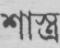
শাস্ত্ৰ
